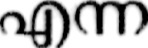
എന്ന
